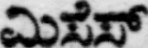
ಮಿಸೆಸ್
